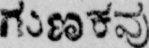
ಗುಣಕವು
